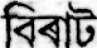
বিৰাট
